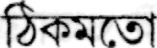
ঠিকমতো
